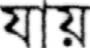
যায়
